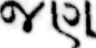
જણ
